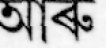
আৰু
